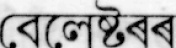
বেলেষ্টৰৰ
